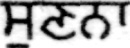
ਸੁਣਨਾ
